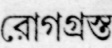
রোগগ্রস্ত
